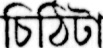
চিঠিটা
